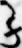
કે
